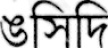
ঙসিদি
